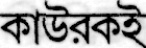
কাউরকই
